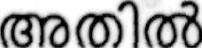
അതില്‍
